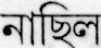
নাছিল
